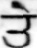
ਤੇ
